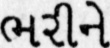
ભરીને
